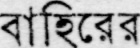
বাহিরের
